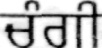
ਚੰਗੀ
